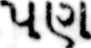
પણ
